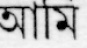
আমি
